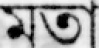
মতা
